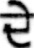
ਦੇ
